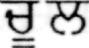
ਚੂਲ
